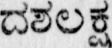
ದಶಲಕ್ಷ
